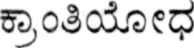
ಕ್ರಾಂತಿಯೋಧ
